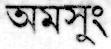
অমসুং
